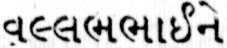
વલ્લભભાઈને
